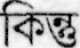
কিন্তু
